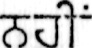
ਨਹੀਂ
